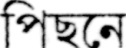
পিছনে
